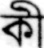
কী
